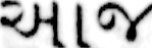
આજ
